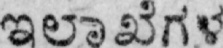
ಇಲಾಖೆಗಳ
